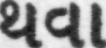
થવા
